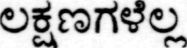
ಲಕ್ಷಣಗಳೆಲ್ಲ
